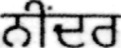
ਨੀਂਦਰ
